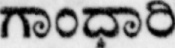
ಗಾಂಧಾರಿ
